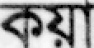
কয়া
